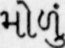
મોળું
